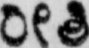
ರೀತಿ
